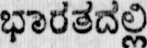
ಭಾರತದಲ್ಲಿ
